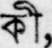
কী,
